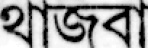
থাজবা
